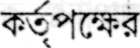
কর্তৃপক্ষের
